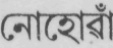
নোহোৱাঁ
